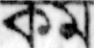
কম
